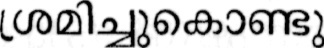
ശ്രമിച്ചുകൊണ്ടു
